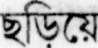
ছড়িয়ে
